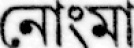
নোংমা
